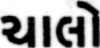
ચાલો
